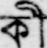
কী
